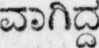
ವಾಗಿದ್ದ
